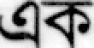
এক
